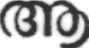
ആ
